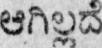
ಆಗಿಲ್ಲದೆ
